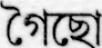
গৈছো
